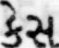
કેસ
